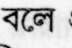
বলে
